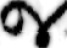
જ
